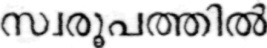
സ്വരൂപത്തില്‍
